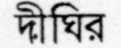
দীঘির
